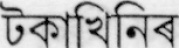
টকাখিনিৰ
